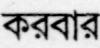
করবার
